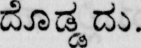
ದೊಡ್ಡದು.
